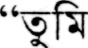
“তুমি
